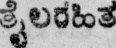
ತೈಲರಹಿತ
